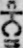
ਨੂੰ
